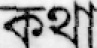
কথা
